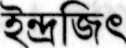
ইন্দ্রজিৎ
